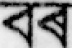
বৰ
